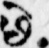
છે.
